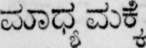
ಮಾಧ್ಯಮಕ್ಕೆ
